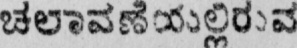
ಚಲಾವಣೆಯಲ್ಲಿರುವ
